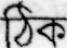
ঠিক
